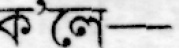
ক'লে-
